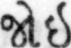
જોઈ
